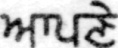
ਆਪਣੇ
